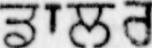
ਡਾਲਰ
